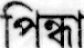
পিন্ধা
